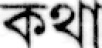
কথা
